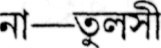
না-তুলসী
